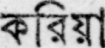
করিয়া
